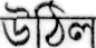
উঠিল
